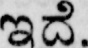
ಇದೆ.
